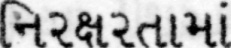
નિરક્ષરતામાં
